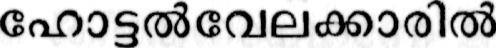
ഹോട്ടല്‍വേലക്കാരില്‍
